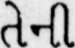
તેની
